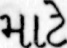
માટે
